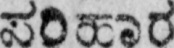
ಪರಿಹಾರ
